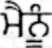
ਮੈਨੂੰ
